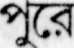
পুরে
